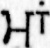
ਮਾਂ
